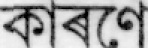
কাৰণে
